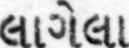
લાગેલા
